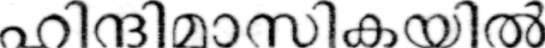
ഹിന്ദിമാസികയില്‍
